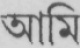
আমি
